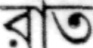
রাত
